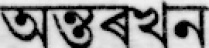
অন্তৰখন
